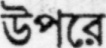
উপরে
